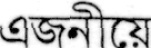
এজনীয়ে
